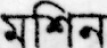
মশিন
